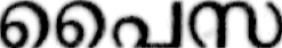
പൈസ
